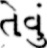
તેવું
